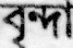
বৃন্দা
